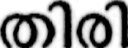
തിരി
